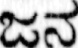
ಜನ
